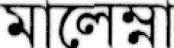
মালেম্না
